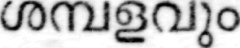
ശമ്പളവും
